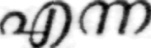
എന്ന
